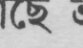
পাছে
